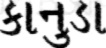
કાનુડા
